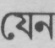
যেন
